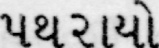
પથરાયો
